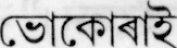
ভোকোৰাই
